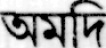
অমদি
